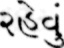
રહેવું
